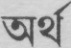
অৰ্থ
